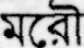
মরৌ
